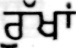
ਰੁੱਖਾਂ
